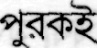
পুরকই
